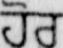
ਹੋਰ
